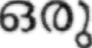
ഒരു
